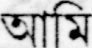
আমি
